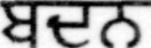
ਬਦਨ
